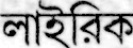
লাইরিক
